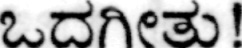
ಒದಗೀತು!
